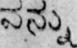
ವನ್ನು
